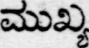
ಮುಖ್ಯ
